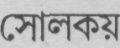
সোলকয়
